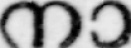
നാ
